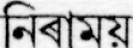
নিৰাময়
